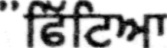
''ਫਿੱਟਿਆ
